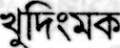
খুদিংমক
